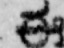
ಈ
